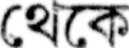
থেকে
